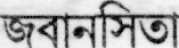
জবানসিতা
